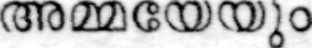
അമ്മയേയും
